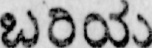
ಬರಿಯ
